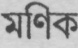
মণিক
